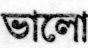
ভালো
